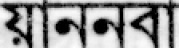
য়াননবা
